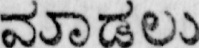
ಮಾಡಲು
